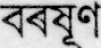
বৰষূণ
